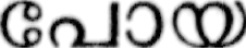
പോയ
